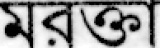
মরক্তা
